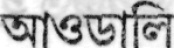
আওডালি
